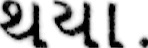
થયા.
